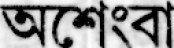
অশেংবা
